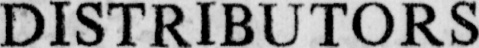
DISTRIBUTORS
